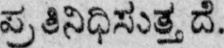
ಪ್ರತಿನಿಧಿಸುತ್ತದೆ.
